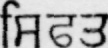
ਸਿਫਤ
